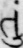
તું
